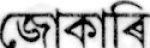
জোকাৰি
